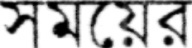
সময়ের
